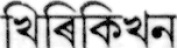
খিৰিকিখন
